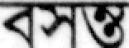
বসন্ত
